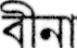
বীনা
